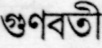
গুণবতী
